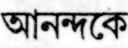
আনন্দকে
